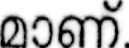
മാണ്.
